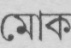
মোক
